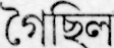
গৈছিল
